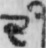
ਦੀ
